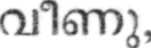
വീണു,
